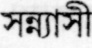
সন্ন্যাসী
